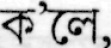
ক'লে,
